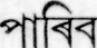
পাৰিব
